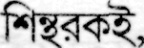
শিন্থরকই,
